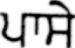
ਪਾਸੇ
